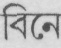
বিনে
